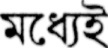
মধ্যেই
